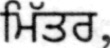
ਮਿੱਤਰ,
